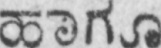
ಹಾಗೂ
